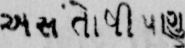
અસંષીપણુ
